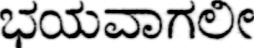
ಭಯವಾಗಲೀ
